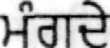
ਮੰਗਦੇ
